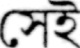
সেই
